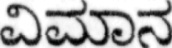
ವಿಮಾನ
